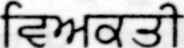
ਵਿਅਕਤੀ
